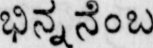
ಭಿನ್ನನೆಂಬ
